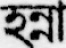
হন্না
